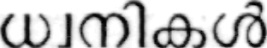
ധ്വനികള്‍
